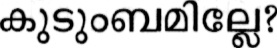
കുടുംബമില്ലേ?
